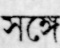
সঙ্গে
